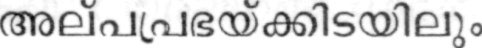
അല് പപ്രഭയ്ക്കിടയിലും
